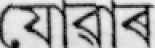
যোৱাৰ
